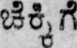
ಚೆಕ್ಕಿಗೆ
